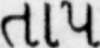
તાપ
